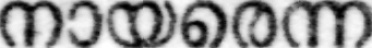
നായരെന്ന
